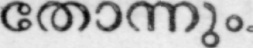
തോന്നും.
